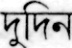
দুদিন
